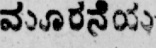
ಮೂರನೆಯ
